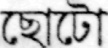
ছোটো
